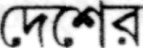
দেশের
